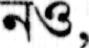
নও,
